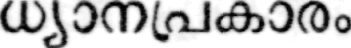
ധ്യാനപ്രകാരം
